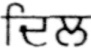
ਦਿਲ
